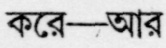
করে–আর
